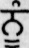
ਨੂੰ
